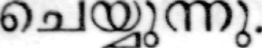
ചെയ്യുന്നു.
